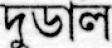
দুডাল
